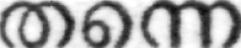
തന്നെ
